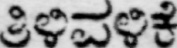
ತಿಳಿವಳಿಕೆ
